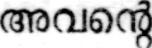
അവന്റെ
